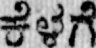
ಕೆಳಗೆ
